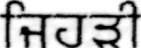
ਜਿਹੜੀ
